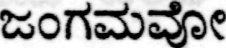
ಜಂಗಮವೋ
